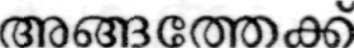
അങ്ങത്തേക്ക്
